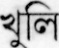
খুলি
